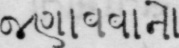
જણાવવાનો
